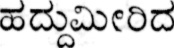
ಹದ್ದುಮೀರಿದ
